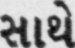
સાથે
